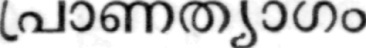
പ്രാണത്യാഗം
